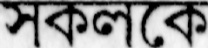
সকলকে
